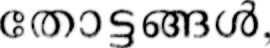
തോട്ടങ്ങള്‍,
